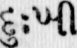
દુઃખી
